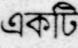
একটি
